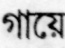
গায়ে
